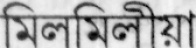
মিলমিলীয়া
